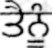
ਤੈਨੂੰ
